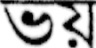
ভয়
